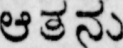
ಆತನು
